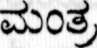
ಮಂತ್ರ
